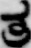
ತ
